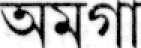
অমগা
